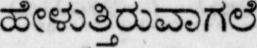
ಹೇಳುತ್ತಿರುವಾಗಲೆ
